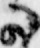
જે
